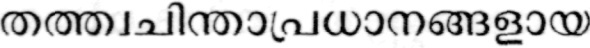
തത്ത്വചിന്താപ്രധാനങ്ങളായ
